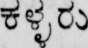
ಕಳ್ಳರು
